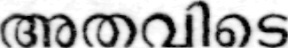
അതവിടെ
